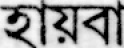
হায়বা
